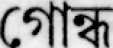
গোন্ধ
